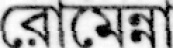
রোমেন্না
